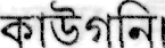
কাউগনি।
